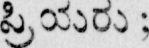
ಪ್ರಿಯರು;
